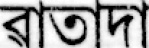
ৱাতাদা
